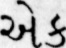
એક
